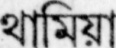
থামিয়া
